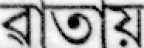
ৱাতায়
